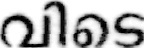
വിടെ
